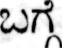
ಬಗ್ಗೆ
